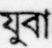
যুবা
